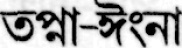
তপ্না-ঈংনা
